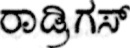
ರಾಡ್ರಿಗಸ್
